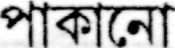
পাকানো
